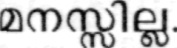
മനസ്സില്ല.
